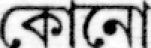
কোনো
